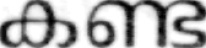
കണ്ട
